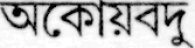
অকোয়বদু
